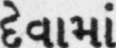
દેવામાં
